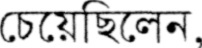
চেয়েছিলেন,
